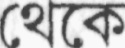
থেকে
